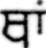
ਥਾਂ
